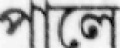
পালে
